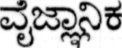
ವೈಜ್ಞಾನಿಕ
